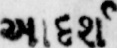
આદર્શ
